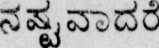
ನಷ್ಟವಾದರೆ
